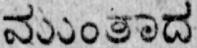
ಮುಂತಾದ
